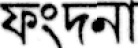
ফংদনা
